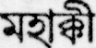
মহাক্কী
